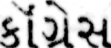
કૉંગ્રેસ
